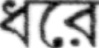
ধরে
